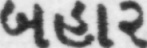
બહાર
